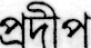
প্ৰদীপ
